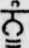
ਨੂੰ
